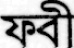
ফবী
